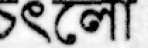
চৎলো
